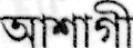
আশাগী
